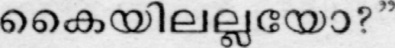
കൈയിലല്ലയോ?"
